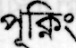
পূক্নিং
